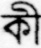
কী
